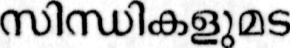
സിന്ധികളുമട
